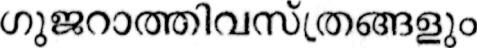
ഗുജറാത്തിവസ്ത്രങ്ങളും
